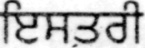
ਇਸਤਰੀ
